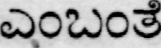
ಎಂಬಂತೆ
